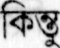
কিন্তু
